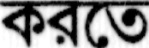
করতে
